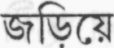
জড়িয়ে
